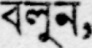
বলুন,
